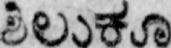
ಶಿಲುಕೂ
